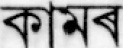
কামৰ
